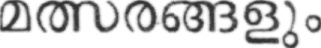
മത്സരങ്ങളും
